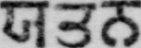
ਯਤਨ
